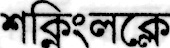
শক্নিংলক্লে
